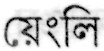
য়েংলি
